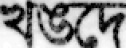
খঙদে
